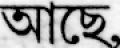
আছে,
